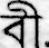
বী.
